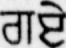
ਗਏ
